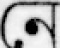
নে
